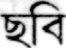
ছবি
